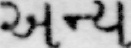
અન્ય
